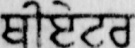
ਥੀਏਟਰ
